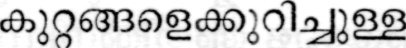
കുറ്റങ്ങളെക്കുറിച്ചുള്ള
